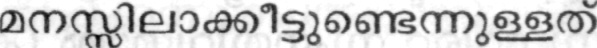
മനസ്സിലാക്കീട്ടുണ്ടെന്നുള്ളത്
